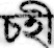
চহী
